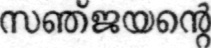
സഞ്ജയന്റെ
